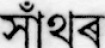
সাঁথৰ
